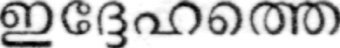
ഇദ്ദേഹത്തെ
